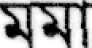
মমা
